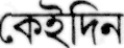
কেইদিন
